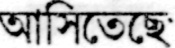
আসিতেছে
